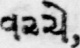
વચ્ચે,
